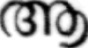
ആ
